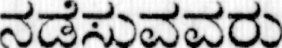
ನಡೆಸುವವರು
